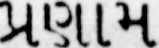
પ્રણામ
